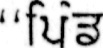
''ਪਿੰਡ
